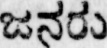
ಜನರು
